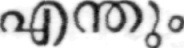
എന്തും
